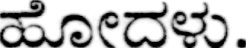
ಹೋದಳು.
